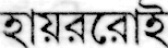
হায়ররোই
